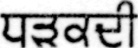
ਧੜਕਦੀ
